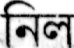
নিল
